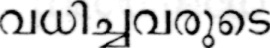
വധിച്ചവരുടെ
